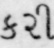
કરી
